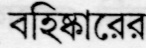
বহিষ্কারের
